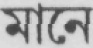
মানে
